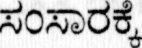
ಸಂಸಾರಕ್ಕೆ
